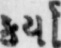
કર્યા
